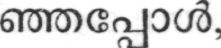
ഞ്ഞപ്പോള്‍,
